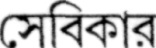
সেবিকার
